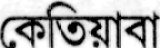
কেতিয়াবা
